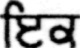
ਇਕ
